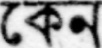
কেন
